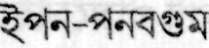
ইপন-পনবগুম
